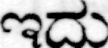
ಇದು
